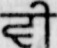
ਵੀ
